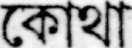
কোথা
